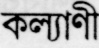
কল্যাণী
